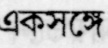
একসঙ্গে
